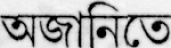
অজানিতে
